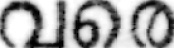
വരെ
